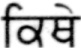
ਕਿਥੇ
